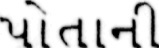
પોતાની
